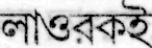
লাওরকই
